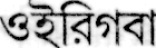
ওইরিগবা
